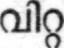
വിറ്റ
